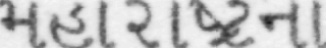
મહારાષ્ટ્રના
